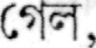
গেল,
